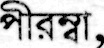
পীরম্বা,
